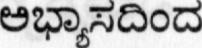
ಅಭ್ಯಾಸದಿಂದ
